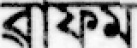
ৱাফম
